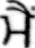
ਮੈਂ
